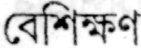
বেশিক্ষণ
